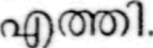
എത്തി.
